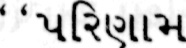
"પરિણામ
